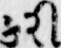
કરી?
